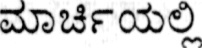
ಮಾರ್ಚಿಯಲ್ಲಿ
